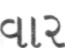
વાર
